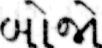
બોજો
